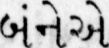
બંનેએ
